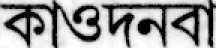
কাওদনবা
